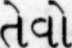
તેવો
